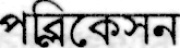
পব্লিকেসন
